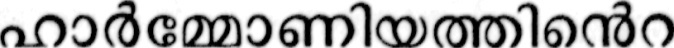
ഹാര്‍മ്മോണിയത്തിന്റെ
